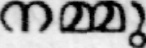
നമ്മു
